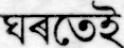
ঘৰতেই
